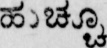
ಹುಚ್ಚೂ
